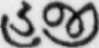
હજી
